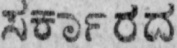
ಸರ್ಕಾರದ
